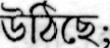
উঠিছে;
